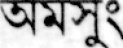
অমসুং
